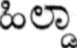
ಹಿಲ್ಡಾ
